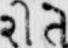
રીતે
